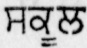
ਸਕੂਲ
